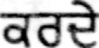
ਕਰਦੇ
